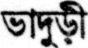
ভাদুড়ী
